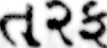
તરફ
